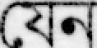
যেন
